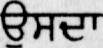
ਉਸਦਾ
